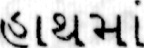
હાથમાં
